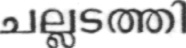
ചല്ലടത്തി
